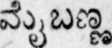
ಮೈಬಣ್ಣ
